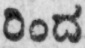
ರಿಂದ
